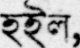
হইল,
